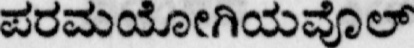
ಪರಮಯೋಗಿಯವೊಲ್
